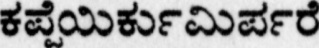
ಕಪ್ಪೆಯಿರ್ಕುಮಿರ್ಪರೆ
